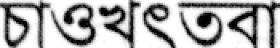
চাওখৎতবা
